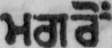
ਮਗਰੋਂ
